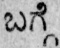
ಬಗ್ಗೆ
